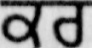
ਕਰ
